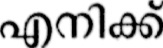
എനിക്ക്
